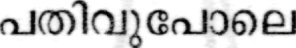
പതിവുപോലെ
